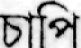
চাপি
